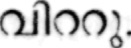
വിററു.
